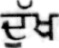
ਦੁੱਖ
